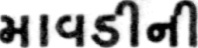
માવડીની
